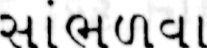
સાંભળવા
